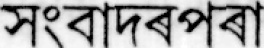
সংবাদৰপৰা
